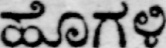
ಹೊಗಳಿ
